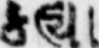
કહ્યા
